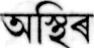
অস্থিৰ
